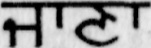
ਜਾਣਾ
